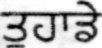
ਤੁਹਾਡੇ
